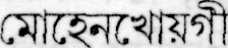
মোহেনখোয়গী
